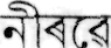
নীৰৱে
